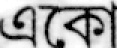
একো
